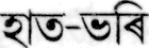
হাত-ভৰি
